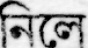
নিলে
